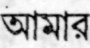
আমার
